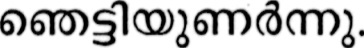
ഞെട്ടിയുണര്‍ന്നു.
